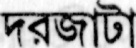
দরজাটা
